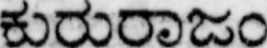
ಕುರುರಾಜಂ
